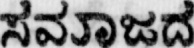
ಸಮಾಜದ
